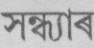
সন্ধ্যাৰ
